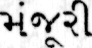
મંજૂરી
